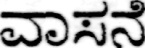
ವಾಸನೆ
